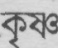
কৃষ্ণ
